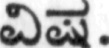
ವಿಷ.
